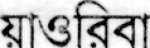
য়াওরিবা
